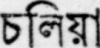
চলিয়া
